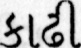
કાઢી
